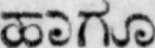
ಹಾಗೂ
